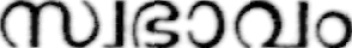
സ്വഭാവം
